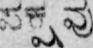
ಪಕ್ಷವು
